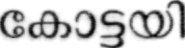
കോട്ടയി
